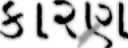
કારણ
